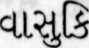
વાસુકિ
